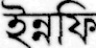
ইন্নফি
